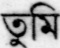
তুমি
